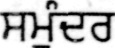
ਸਮੁੰਦਰ
